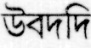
উবদদি
